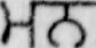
ਮਨ
